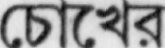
চোখের
